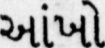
આંખો
